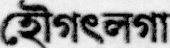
হৌগৎলগা
